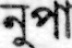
নুপা
